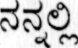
ನನ್ನಲ್ಲಿ
